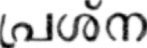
പ്രശ്ന
